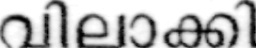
വിലാക്കി
